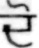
ਦੋ
